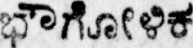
ಭೌಗೋಳಿಕ
